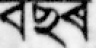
বছৰ
